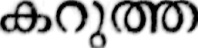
കറുത്ത
